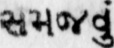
સમજવું
